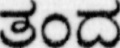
ತಂದ
